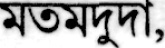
মতমদুদা,
